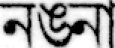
নঙনা
